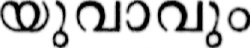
യുവാവും
